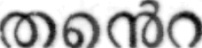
തന്റെ
